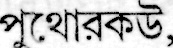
পুথোরকউ,
